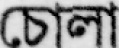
চোলা
